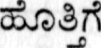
ಹೊತ್ತಿಗೆ
